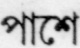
পাশে
